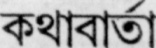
কথাবার্তা
